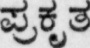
ಪ್ರಕೃತ
